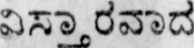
ವಿಸ್ತಾರವಾದ
